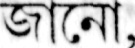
জানো,
